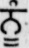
ਨੂੰ
